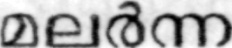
മലര്‍ന്ന
